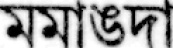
মমাঙদা
